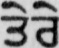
ਤੇਰੇ
